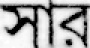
সার
